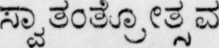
ಸ್ವಾತಂತ್ರೋತ್ಸವ
